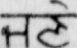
ਜਣੇ
